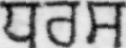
ਧਰਸ
